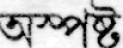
অস্পষ্ট
